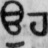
ਉਹ
